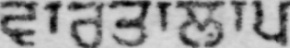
ਵਾਰਤਾਲਾਪ
